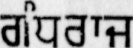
ਗੰਧਰਾਜ
